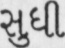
સુધી
